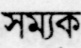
সম্যক
